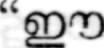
“ഈ
